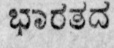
ಭಾರತದ
